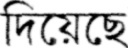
দিয়েছে
